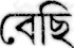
বেছি
